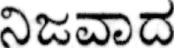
ನಿಜವಾದ
